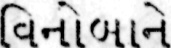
વિનોબાને
